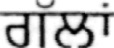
ਗੱਲਾਂ
